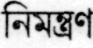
নিমন্ত্রণ
